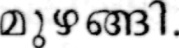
മുഴങ്ങി.
